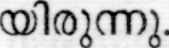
യിരുന്നു.
